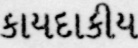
કાયદાકીય
